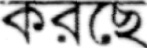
করছে
